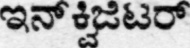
ಇನ್ಕ್ವಿಜಿಟರ್
